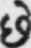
છે
